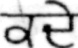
ਕਦੇ
